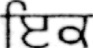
ਇਕ
